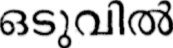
ഒടുവില്‍
